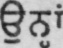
ਉਨ੍ਹਾਂ
